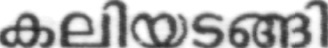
കലിയടങ്ങി
